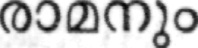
രാമനും
